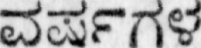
ವರ್ಷಗಳ
